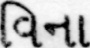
વિના
